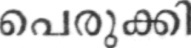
പെരുക്കി
